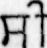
ਸੀ
